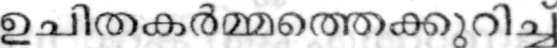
ഉചിതകര്‍മ്മത്തെക്കുറിച്ച്
